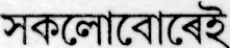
সকলোবোৰেই
